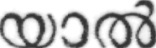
യാല്‍
